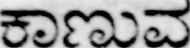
ಕಾಣುವ
